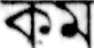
কম
